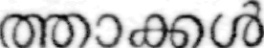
ത്താക്കള്‍
